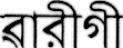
ৱারীগী
